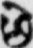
છે
